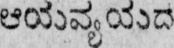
ಆಯವ್ಯಯದ
